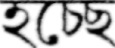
হচ্ছে
